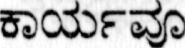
ಕಾರ್ಯವೂ
